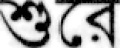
শুরে
